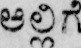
ಅಲ್ಲಿಗೆ
